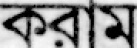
করাম
